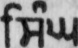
ਸਿੰਘ
